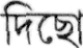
দিছো
